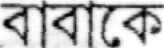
বাবাকে
